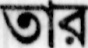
তার
